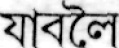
যাবলৈ
